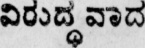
ವಿರುದ್ಧವಾದ
